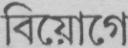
বিয়োগে
